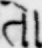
તો
